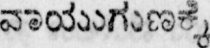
ವಾಯುಗುಣಕ್ಕೆ
